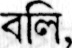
বলি,
